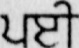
ਪਈ
